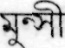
মুন্সী
